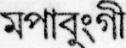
মপাবুংগী
